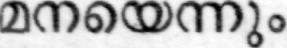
മനയെന്നും
